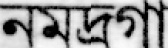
নমদ্রগা
